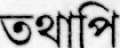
তথাপি
